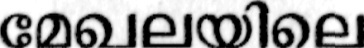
മേഖലയിലെ
